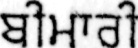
ਬੀਮਾਰੀ
